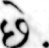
છે.
